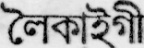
লৈকাইগী
